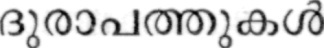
ദുരാപത്തുകള്‍
